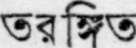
তরঙ্গিত
